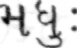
મધુઃ
